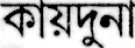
কায়দুনা
